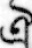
ঐ
